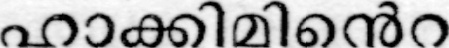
ഹാക്കിമിന്റെ
